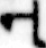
ન
